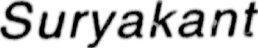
Suryakant
